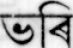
ভৰি
